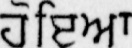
ਹੋਇਆ
